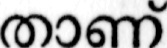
താണ്
